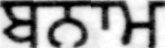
ਬਨਾਮ
